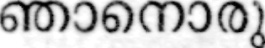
ഞാനൊരു
